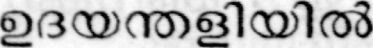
ഉദയന്തളിയില്‍
